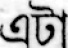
এটা
